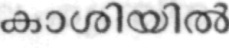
കാശിയില്‍
